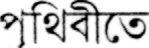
পৃথিবীতে
